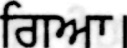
ਗਿਆ।
